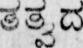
ತತ್ವದ
